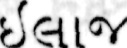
ઇલાજ
